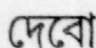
দেবো
